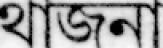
থাজনা
